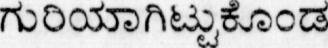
ಗುರಿಯಾಗಿಟ್ಟುಕೊಂಡ
